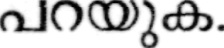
പറയുക.
